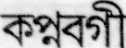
কপ্নবগী
